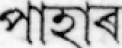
পাহাৰ
